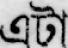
এটা
